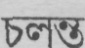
চলন্ত
